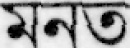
মনত
